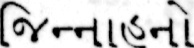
જિન્નાહનો
